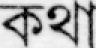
কথা
